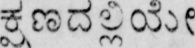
ಕ್ಷಣದಲ್ಲಿಯೇ
